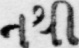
નથી
